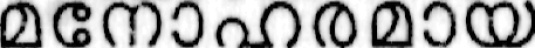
മനോഹരമായ
